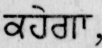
ਕਹੇਗਾ,
